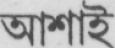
আশাই
